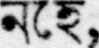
নহে,
